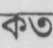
কত
